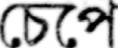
চেপে
